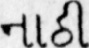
નાઠી
